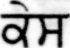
ਕੇਸ
